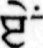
ਏਂ
